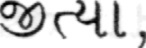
જીત્યા,
